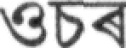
ওচৰ
